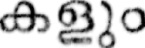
കളും
